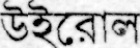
উইরোল
